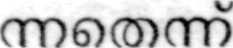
ന്നതെന്ന്
